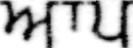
ਆਪ
